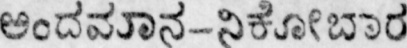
ಅಂದಮಾನ-ನಿಕೋಬಾರ
